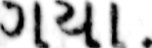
ગયા.
